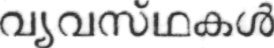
വ്യവസ്ഥകള്‍
